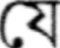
যে
